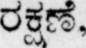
ರಕ್ಷಣೆ,
